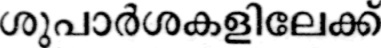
ശുപാര്‍ശകളിലേക്ക്
